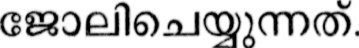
ജോലിചെയ്യുന്നത്.
